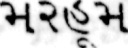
મરહૂમ
